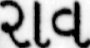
રાવ
